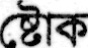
ষ্টোক
